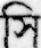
সি
